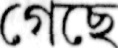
গেছে
